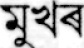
মুখৰ
